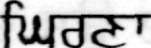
ਘਿਰਣਾ
